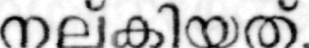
നല്കിയത്.
